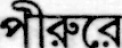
পীরুরে
